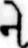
ને
